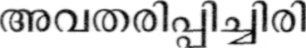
അവതരിപ്പിച്ചിരി
